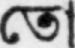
তো
